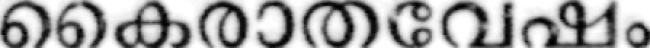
കൈരാതവേഷം
